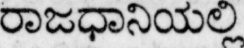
ರಾಜಧಾನಿಯಲ್ಲಿ
